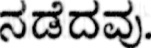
ನಡೆದವು.
